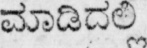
ಮಾಡಿದಲ್ಲಿ
